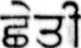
ਛੇਤੀ
